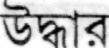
উদ্ধার
